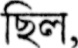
ছিল,
